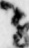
કે
